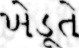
ખેડૂતે
